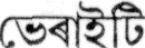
ভেৰাইটি
